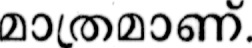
മാത്രമാണ്.
